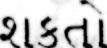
શકતો
